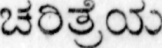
ಚರಿತ್ರೆಯ
